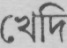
খেদি
